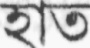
হাত
